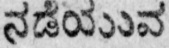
ನಡೆಯುವ
